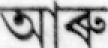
আৰু
